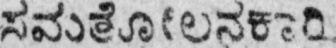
ಸಮತೋಲನಕಾರಿ
